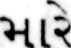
મારે
